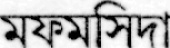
মফমসিদা
